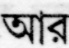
আর
